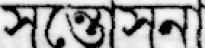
সন্তোসনা
